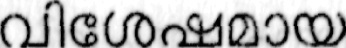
വിശേഷമായ
